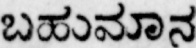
ಬಹುಮಾನ
